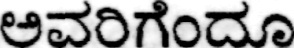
ಅವರಿಗೆಂದೂ
